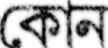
কোন
